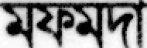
মফমদা
